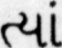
ત્યાં
